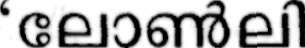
‘ലോണ്‍ലി
